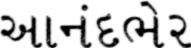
આનંદભેર
